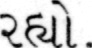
રહ્યો.
